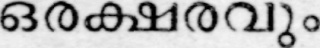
ഒരക്ഷരവും
